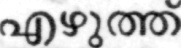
എഴുത്ത്
